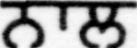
ਨਾਲ
